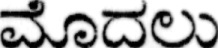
ಮೊದಲು
